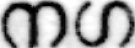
നഗ
